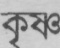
কৃষ্ণ
